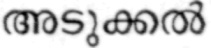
അടുക്കല്‍
